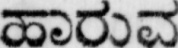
ಹಾರುವ
